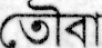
তৌবা
